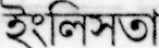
ইংলিসতা
